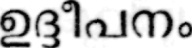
ഉദ്ദീപനം
